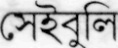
সেইবুলি
